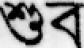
শুব
